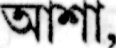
আশা,
